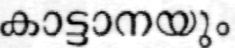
കാട്ടാനയും
